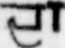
ਦਾ
